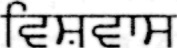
ਵਿਸ਼ਵਾਸ
